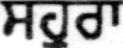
ਸਹੁਰਾ
